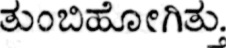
ತುಂಬಿಹೋಗಿತ್ತು.
